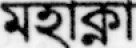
মহাক্না
